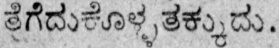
ತೆಗೆದುಕೊಳ್ಳತಕ್ಕುದು.
